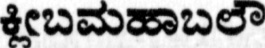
ಕ್ಲೀಬಮಹಾಬಲೌ
